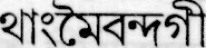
থাংমৈবন্দগী
